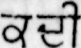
ਕਦੀ
